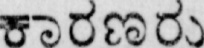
ಕಾರಣರು
